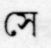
সে
